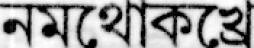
নমথোকখ্রে
